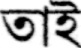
তাই
